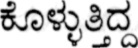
ಕೊಳ್ಳುತ್ತಿದ್ದ
